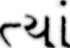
ત્યાં
